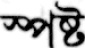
স্পষ্ট
